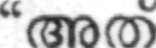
“അത്
